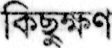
কিছুক্ষণ
